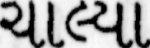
ચાલ્યા
